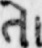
તો
